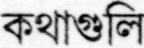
কথাগুলি
